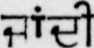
ਜਾਂਦੀ
